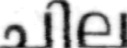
ചില
